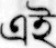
এই
